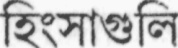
হিংসাগুলি
